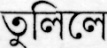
তুলিলে
